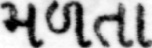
મળતા
